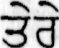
ਤੇਰੇ
